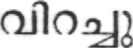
വിറച്ചു
